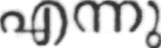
എന്നു
